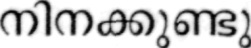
നിനക്കുണ്ടു
